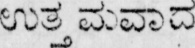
ಉತ್ತಮವಾದ
